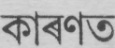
কাৰণত
